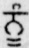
ਨੂੰ
